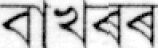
বাখৰৰ
